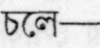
চলে–
